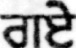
ਗਏ
